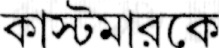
কাস্টমারকে
